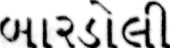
બારડોલી
